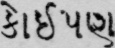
કોઈપણ
